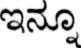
ಇನ್ನೂ
